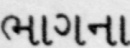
ભાગના
